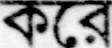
করে
